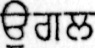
ਉਗਲ
